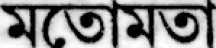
মতোমতা
